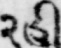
રહી
